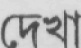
দেখা
